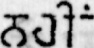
ਨਹੀਂ
